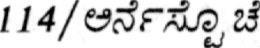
114/ಆರ್ನೆಸ್ಟೊಚೆ
